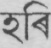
হৰি
